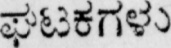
ಘಟಕಗಳು
